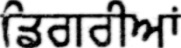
ਡਿਗਰੀਆਂ
